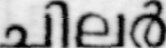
ചിലര്‍
